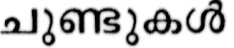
ചുണ്ടുകള്‍
